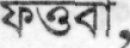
ফত্তবা,
